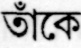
তাঁকে
